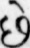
છે
